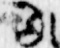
છો
